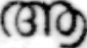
ആ
